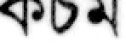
কচম
